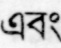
এবং
